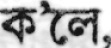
ক'লে,
